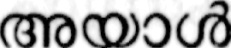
അയാള്‍
